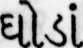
ઘોડાં
